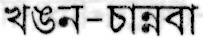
খঙন-চান্নবা
